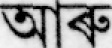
আৰু
